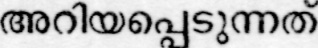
അറിയപ്പെടുന്നത്
